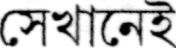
সেখানেই
